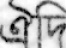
ঐদি
